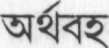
অর্থবহ
